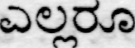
ಎಲ್ಲರೂ
